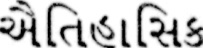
ઐતિહાસિક
